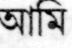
আমি
